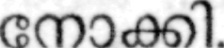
നോക്കി.
